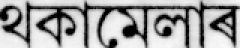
থকামেলাৰ
